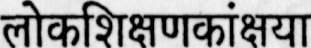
लोकशिक्षणकांक्षया
